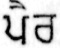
ਪੈਰ
